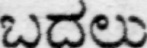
ಬದಲು
